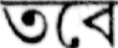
তবে
